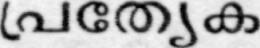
പ്രത്യേക
